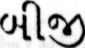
બીજી
